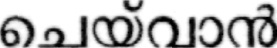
ചെയ്വാന്‍
